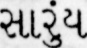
સારુંય
